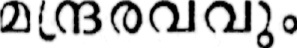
മന്ദ്രരവവും
